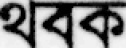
থবক
